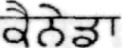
ਕੈਨੇਡਾ
